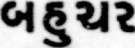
બહુચર
